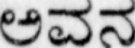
ಅವನ
